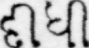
દીધી
